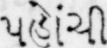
પહોંચી
